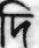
দি
